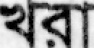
খরা
